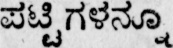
ಪಟ್ಟಿಗಳನ್ನೂ
